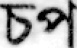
চপ
